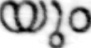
യും
